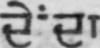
ਦੇਂਦਾ
